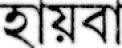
হায়বা
